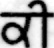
ਕੀ
